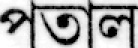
পতাল
